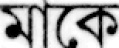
মাকে
